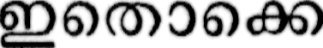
ഇതൊക്കെ
